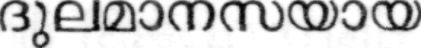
ദുലമാനസയായ
